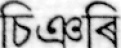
চিঞৰি
